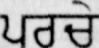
ਪਰਚੇ
